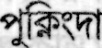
পুক্নিংদা
